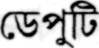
ডেপুটি
